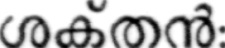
ശക്തന്‍:
